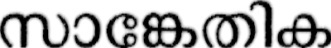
സാങ്കേതിക
